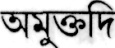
অমুক্তদি
